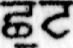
ਛੁਟ
